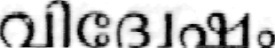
വിദ്വേഷം
